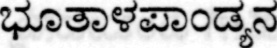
ಭೂತಾಳಪಾಂಡ್ಯನ
